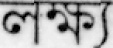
লক্ষ্য
